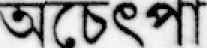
অচেৎপা
